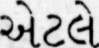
એટલે
